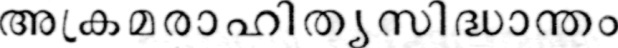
അക്രമരാഹിത്യസിദ്ധാന്തം
